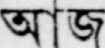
আজ
